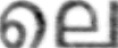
ലെ
